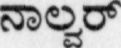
ನಾಲ್ವರ್
